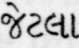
જેટલા
